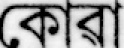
কোৱা
